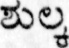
ಶುಲ್ಕ
